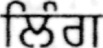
ਲਿੰਗ
